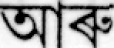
আৰু
